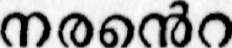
നരന്റെ
